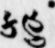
કહું
